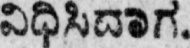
ವಿಧಿಸಿದಾಗ.
